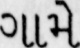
ગામે
